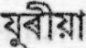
যুৰীয়া
